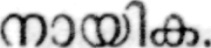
നായിക.
